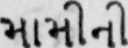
મામીની
